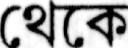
থেকে
